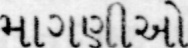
માગણીઓ
